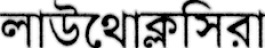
লাউথোক্লসিরা
